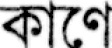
কাণে
